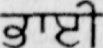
ਭਾਈ
